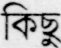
কিছু
